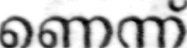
ണെന്ന്
